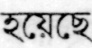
হয়েছে
